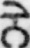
ਨੇ
